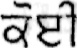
ਕੋਈ
